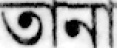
তানা
